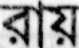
রায়
